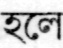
হলে
